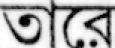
তারে
